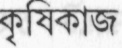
কৃষিকাজ
